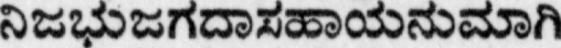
ನಿಜಭುಜಗದಾಸಹಾಯನುಮಾಗಿ
